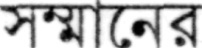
সম্মানের
